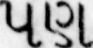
પણ
